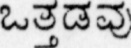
ಒತ್ತಡವು
